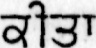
ਕੀਤਾ
